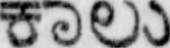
ಕಾಲು
